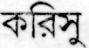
করিসু
